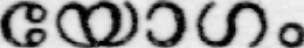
യോഗം
